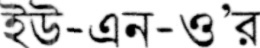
ইউ-এন-ও’র
